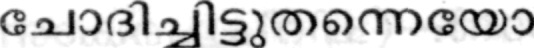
ചോദിച്ചിട്ടുതന്നെയോ
